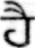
ਹੈ
